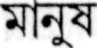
মানুষ
